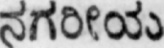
ನಗರೀಯ
